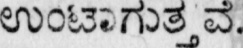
ಉಂಟಾಗುತ್ತವೆ.
